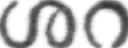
ശറ
